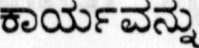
ಕಾರ್ಯವನ್ನು
